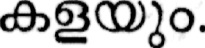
കളയും.
